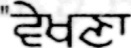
''ਵੇਖਣਾ
